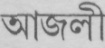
আজলী
